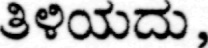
ತಿಳಿಯದು,
